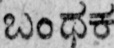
ಬಂಧಕ
